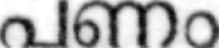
പണം
